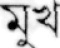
মুখ
